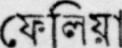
ফেলিয়া
